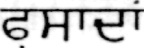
ਫ਼ਸਾਦਾਂ
